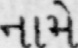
નામે
